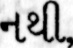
નથી,
